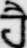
ਹੈ
